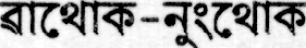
ৱাথোক-নুংথোক
